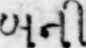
બની
